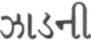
ઝાડની
